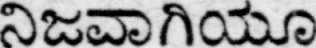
ನಿಜವಾಗಿಯೂ
